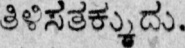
ತಿಳಿಸತಕ್ಕುದು.
